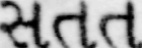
સતત
